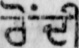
ਰੋਂਦੀ
